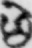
છે
